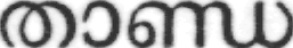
താണ്ഡ
